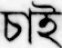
চাই
